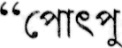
“পোৎপু
